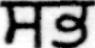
ਸਭ
